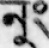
নুং
